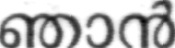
ഞാന്‍
